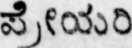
ಪ್ರೇಯರಿ
